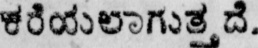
ಕರೆಯಲಾಗುತ್ತದೆ.
